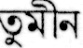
তুমীন
